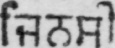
ਜਿਨਸੀ
